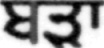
ਬੜਾ
